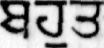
ਬਹੁਤ
